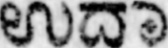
ಉದಾ
